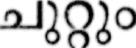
ചുറ്റും
